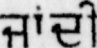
ਜਾਂਦੀ
